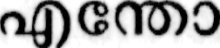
എന്തോ
